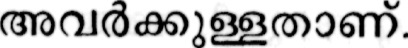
അവര്‍ക്കുള്ളതാണ്.
